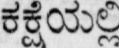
ಕಕ್ಷೆಯಲ್ಲಿ
